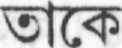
তাকে
